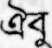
ঐবু
